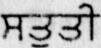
ਸਤੁਤੀ
